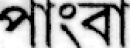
পাংবা
